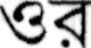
ওর
